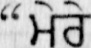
''ਮੇਰੇ
